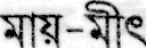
মায়-মীৎ
